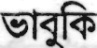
ভাবুকি
